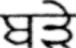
ਬੜੇ
